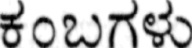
ಕಂಬಗಳು
